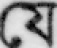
যে
